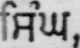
ਸਿੰਘ,
